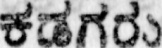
ಕಡಗರು
